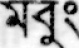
মবুং
